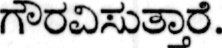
ಗೌರವಿಸುತ್ತಾರೆ.
